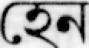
হেন
